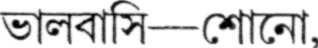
ভালবাসি–শোনো,
